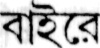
বাইরে
